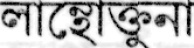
লান্থোক্তুনা
